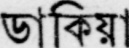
ডাকিয়া
